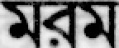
মরম
